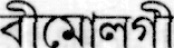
বীমোলগী
